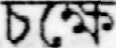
চক্ষে
